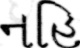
નહિ
